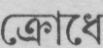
ক্ৰোধে
